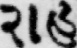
રાહ
